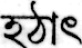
হঠাৎ
